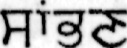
ਸਾਂਭਣ
